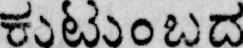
ಕುಟುಂಬದ
